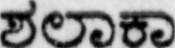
ಶಲಾಕಾ
